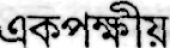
একপক্ষীয়
